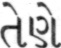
તેણે
